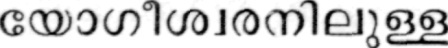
യോഗീശ്വരനിലുള്ള
